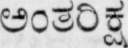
ಅಂತರಿಕ್ಷ
